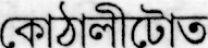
কোঠালীটোত
